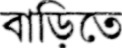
বাড়িতে
